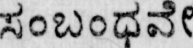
ಸಂಬಂಧವೇ
